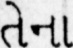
તેના
